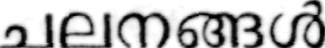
ചലനങ്ങള്‍
